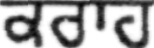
ਕਰਾਹ
